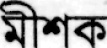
মীশক
